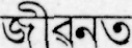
জীৱনত
